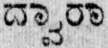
ದ್ವಾರಾ
